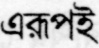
এরূপই
